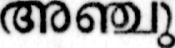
അഞ്ചു
